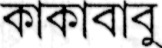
কাকাবাবু
